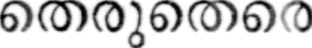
തെരുതെരെ
